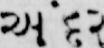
અંદર
